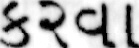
કરવા
